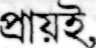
প্রায়ই,
